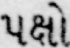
પક્ષો
